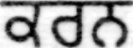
ਕਰਨ
